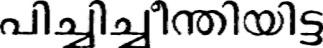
പിച്ചിച്ചീന്തിയിട്ട
